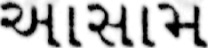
આસામ
